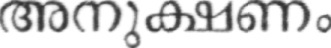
അനുക്ഷണം
